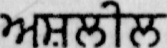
ਅਸ਼ਲੀਲ
